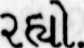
રહ્યો.
